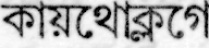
কায়থোক্লগে
